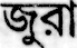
জুরা
